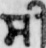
ਸੀ
